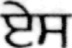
ਏਸ
